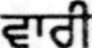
ਵਾਰੀ
